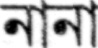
নানা
